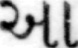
આ
